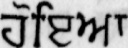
ਹੋਇਆ
